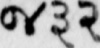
જરૂર
